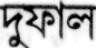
দুফাল
